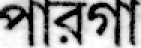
পারগা
